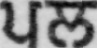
ਪਲ
